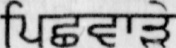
ਪਿਛਵਾੜੇ
